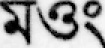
মওং
